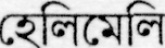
হেলিমেলি
